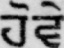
ਹੋਵੇ
